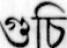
গুচি
